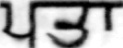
ਪਤਾ
